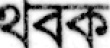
থবক
